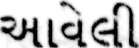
આવેલી
